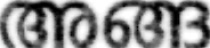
അങ്ങ
